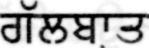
ਗੱਲਬਾਤ
